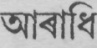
আৰাধি
